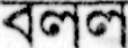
বলল
